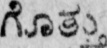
ಗೊತ್ತು
